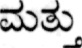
ಮತ್ತು
